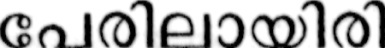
പേരിലായിരി
